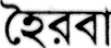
হৈরবা
